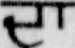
ਦਾ
